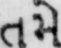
તમે
